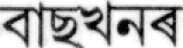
বাছখনৰ
